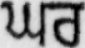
ਘਰ
